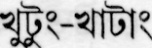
খুটুং-খাটাং
